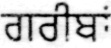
ਗਰੀਬਾਂ
